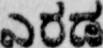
ಎರಡ
